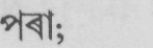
পৰা;
